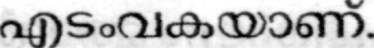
എടംവകയാണ്.
